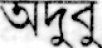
অদুবু
